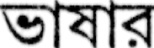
ভাষার
